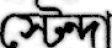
স্টেন্দা
